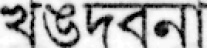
খঙদবনা
